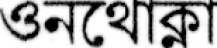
ওনথোক্না
